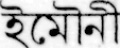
ইমৌনী
